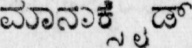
ಮಾನಾಕ್ಸೈಡ್
